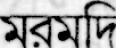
মরমদি
